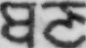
ਬਣ
